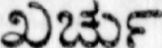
ಖರ್ಚು
